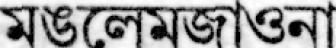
মঙলেমজাওনা
